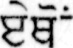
ਏਥੋਂ
